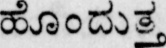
ಹೊಂದುತ್ತ
